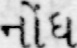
નોંધ
